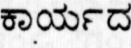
ಕಾರ್ಯದ
